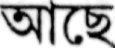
আছে
